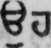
ਉਹ
